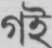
গই
